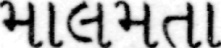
માલમતા
